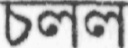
চলল
